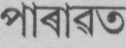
পাৰাৱত
